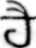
ਹੈ
